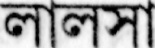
লালসা
